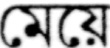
মেয়ে
